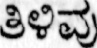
ತಿಳಿವು
